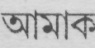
আমাক
